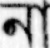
না
